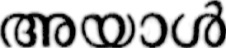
അയാള്‍
